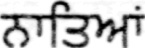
ਨਾਤਿਆਂ
